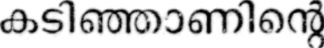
കടിഞ്ഞാണിന്റെ
